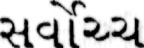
સર્વોચ્ચ
